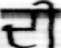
ਦੀ
